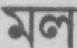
মল
